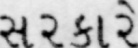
સરકારે
